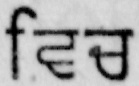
ਵਿਚ
